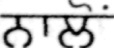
ਨਾਲੋਂ
